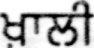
ਖ਼ਾਲੀ
